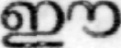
ഈ
